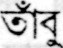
তাঁবু
